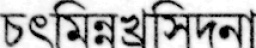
চৎমিন্নখ্রসিদনা
